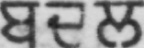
ਬਦਲ
